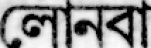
লোনবা
